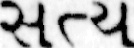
સત્ય
